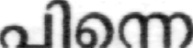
പിന്നെ
